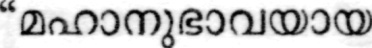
“മഹാനുഭാവയായ
